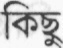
কিছু
